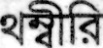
থম্বীরি
